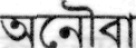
অনৌবা
